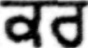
ਕਰ
